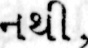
નથી,
